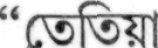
"তেতিয়া
